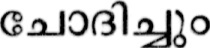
ചോദിച്ചും
